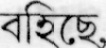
বহিছে,
